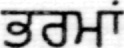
ਭਰਮਾਂ
